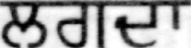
ਲਗਦਾ
